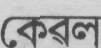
কেৱল
